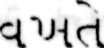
વખતે
